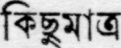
কিছুমাত্র
